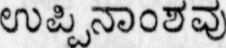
ಉಪ್ಪಿನಾಂಶವು
